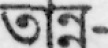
তান্ন-
